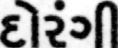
દોરંગી
